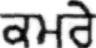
ਕਮਰੇ
